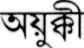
অয়ুক্কী
